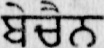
ਬੇਚੈਨ
